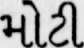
મોટી
